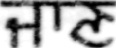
ਜਾਣ
